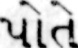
પોતે
